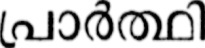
പ്രാര്‍ത്ഥി
